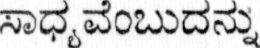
ಸಾಧ್ಯವೆಂಬುದನ್ನು
